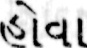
હોવા
